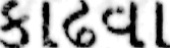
કાઢવા
